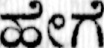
ಹೇಗೆ
